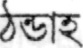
ঠন্ডাহ’
